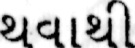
થવાથી
